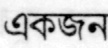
একজন
